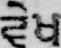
ਵੇਖ
